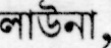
লাউনা,
